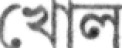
খোল
